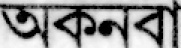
অকনবা
